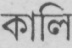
কালি
